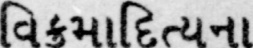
વિક્રમાદિત્યના
